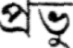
প্রভু
